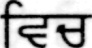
ਵਿਚ
